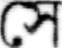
সে
